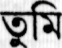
তুমি
